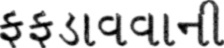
ફફડાવવાની
